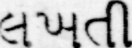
લખતી
